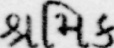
શ્રમિક
